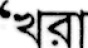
‘খরা
